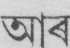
আৰ
